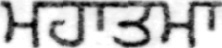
ਮਹਾਤਮਾ
